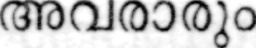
അവരാരും
